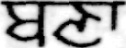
ਬਣਾ
